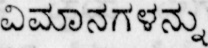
ವಿಮಾನಗಳನ್ನು
